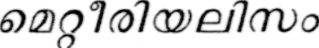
മെറ്റീരിയലിസം
